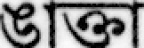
ঙাক্তা
